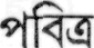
পবিত্র
